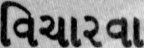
વિચારવા
